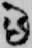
છ
